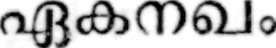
ഏകനഖം
